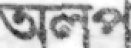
অলপ
